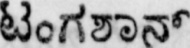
ಟಂಗಶಾನ್
